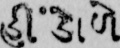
હીંડોળે
